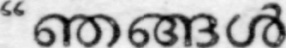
"ഞങ്ങള്‍
